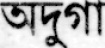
অদুগা
